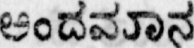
ಅಂದಮಾನ
